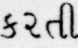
કરતી
